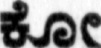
ಕೋ
